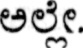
ಅಲ್ಲೇ.
